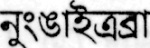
নুংঙাইত্রব্রা
